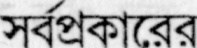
সর্বপ্রকারের
